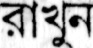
রাখুন
